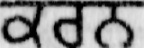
ਕਰਨ
